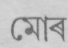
মোৰ
